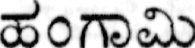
ಹಂಗಾಮಿ
